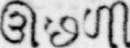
ઊછળી
